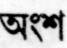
অংশ
